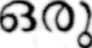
ഒരു
